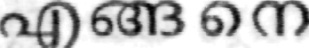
എങ്ങനെ
